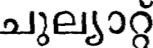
ചുല്യാറ്റ്
